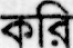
করি
